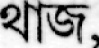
থাজ,
